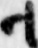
ન
